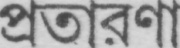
প্রতারণা
